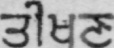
ਤੀਖਣ
